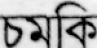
চমকি
